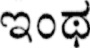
ಇಂಥ
